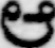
ಆ
